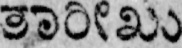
ತಾರೀಖು
